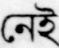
নেই
